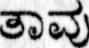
ತಾವು
